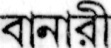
বানারী
